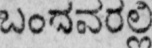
ಬಂದವರಲ್ಲಿ
